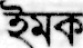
ইমক
